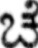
ಚೆ
